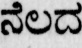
ನೆಲದ
